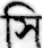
সি
